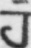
ਹੋ
